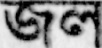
জল
